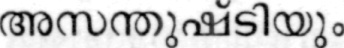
അസന്തുഷ്ടിയും
